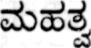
ಮಹತ್ವ
